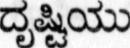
ದೃಷ್ಟಿಯು
